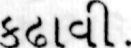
કઢાવી.
